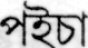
পইচা
